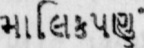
માલિકપણું
